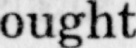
ought
